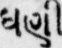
ધણી
